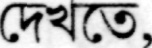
দেখতে,
